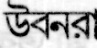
উবনরা
